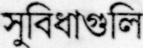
সুবিধাগুলি
